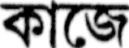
কাজে
